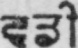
ਵਡੀ
